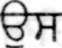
ਉਸ
